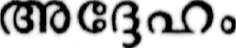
അദ്ദേഹം
